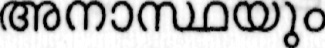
അനാസ്ഥയും
